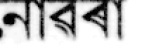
নোৱৰা
